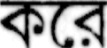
করে
